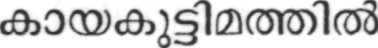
കായകുട്ടിമത്തില്‍
